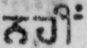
ਨਹੀਂ
